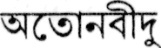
অতোনবীদু
